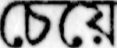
চেয়ে
